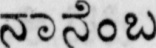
ನಾನೆಂಬ
